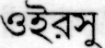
ওইরবসু
